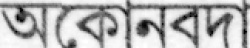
অকোনবদা
